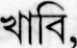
খাবি,
